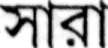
সারা
